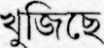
খুজিছে
